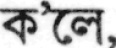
ক'লে,
